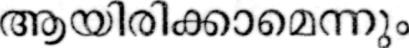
ആയിരിക്കാമെന്നും
